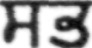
ਸਭ
